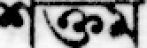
শক্তম
